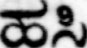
ಹಸಿ
